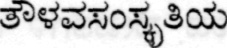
ತೌಳವಸಂಸ್ಕೃತಿಯ
